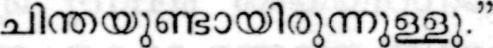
ചിന്തയുണ്ടായിരുന്നുള്ളു.”
